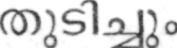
തുടിച്ചും
